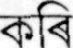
কৰি
